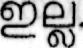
ഇല്ല.
